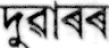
দুৱাৰৰ
